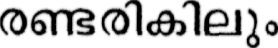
രണ്ടരികിലും
